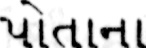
પોતાના
